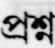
প্রশ্ন
